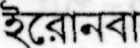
ইরোনবা
